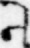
ને
